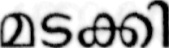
മടക്കി
